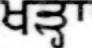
ਖੜ੍ਹਾ
